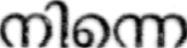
നിന്നെ
